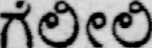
ಗೆಲೀಲಿ
